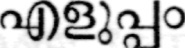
എളുപ്പം
